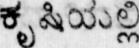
ಕೃಷಿಯಲ್ಲಿ
